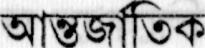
আন্তর্জাতিক
